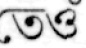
তেওঁ
